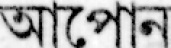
আপোন
